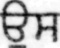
ਉਸ
